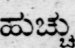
ಹುಚ್ಚು
